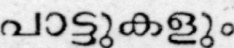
പാട്ടുകളും
